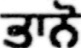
ਭਾਨੋ
